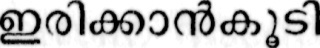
ഇരിക്കാന്‍കൂടി
